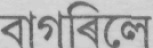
বাগৰিলে
